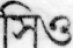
সিও
